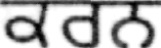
ਕਰਨ
